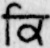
ਕਿ
